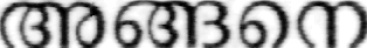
അങ്ങനെ
